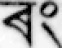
ৰং
